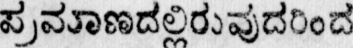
ಪ್ರಮಾಣದಲ್ಲಿರುವುದರಿಂದ
